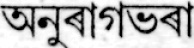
অনুৰাগভৰা
